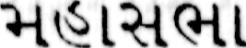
મહાસભા
